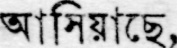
আসিয়াছে,
